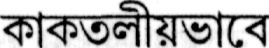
কাকতলীয়ভাবে
